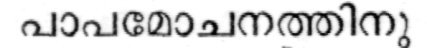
പാപമോചനത്തിനു
